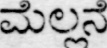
ಮೆಲ್ಲನೆ
